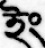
ইং
